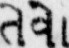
તેવો
